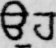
ਉਹ
